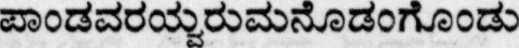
ಪಾಂಡವರಯ್ವರುಮನೊಡಂಗೊಂಡು
